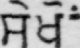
ਸੇਖੋਂ
